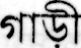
গাড়ী
